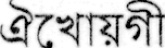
ঐখোয়গী
